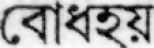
বোধহয়
